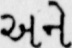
અને
